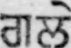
ਗਲੇ
